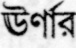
ঊর্ণার
